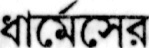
ধার্মেসের
